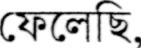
ফেলেছি,
